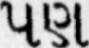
પણ
